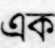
এক
